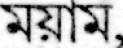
ময়াম,
